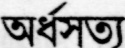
অর্ধসত্য
